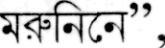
মরুনিনে”,
